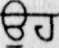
ਉਹ
